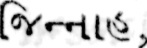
જિન્નાહ,
